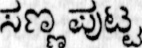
ಸಣ್ಣಪುಟ್ಟ
